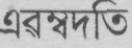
এৱম্বদতি
